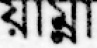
য়াম্না
